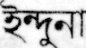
ইন্দুনা
